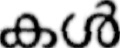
കള്‍
